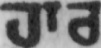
ਹਾਰ
